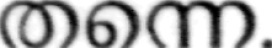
തന്നെ.
